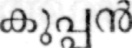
കുപ്പന്‍
